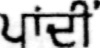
ਪਾਂਦੀ'
